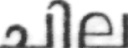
ചില
